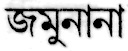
জমুনানা
